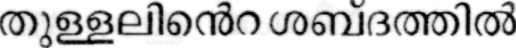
തുള്ളലിന്റെശബ്ദത്തില്‍
